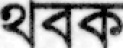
থবক
